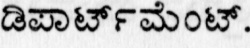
ಡಿಪಾರ್ಟ್‌ಮೆಂಟ್.
